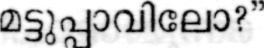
മട്ടുപ്പാവിലോ?”
